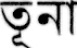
তূনা
